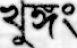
খুঙ্গং
